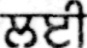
ਲਈ
